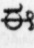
ಈ
